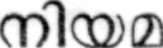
നിയമ
